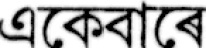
একেবাৰে
